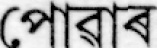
পোৱাৰ
